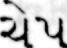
ચેપ
